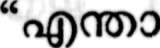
“എന്താ
